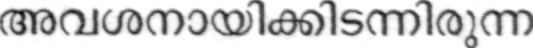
അവശനായിക്കിടന്നിരുന്ന
